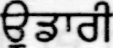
ਉਡਾਰੀ
